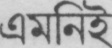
এমনিই
